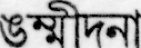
ঙম্মীদনা
